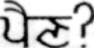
ਪੈਣ?
